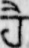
ਹੈ
